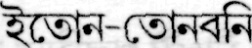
ইতোন-তোনবনি
